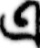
এ
